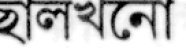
ছালখনো
